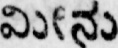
ಮೀನು
